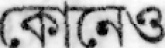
কোনেও
